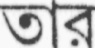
তার
